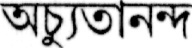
অচ্যুতানন্দ
